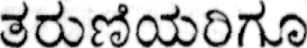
ತರುಣಿಯರಿಗೂ
